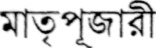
মাতৃপূজারী
